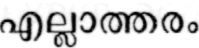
എല്ലാത്തരം
